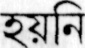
হয়নি
